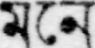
মনে
